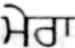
ਮੇਰਾ
